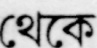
থেকে
